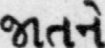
જાતને
